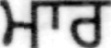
ਮਾਰ
